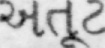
અતૂટ
